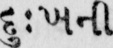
દુઃખની
